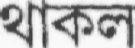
থাকল
